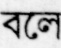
বলে
